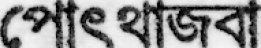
পোৎথাজবা
